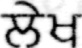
ਲੇਖ
